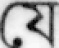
যে
